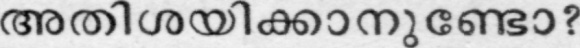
അതിശയിക്കാനുണ്ടോ?
